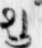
શું
